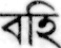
বহি
